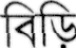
বিড়ি
